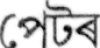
পেটৰ
